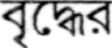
বৃদ্ধের
